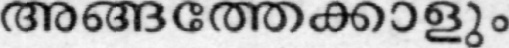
അങ്ങത്തേക്കാളും
